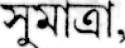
সুমাত্রা,
